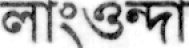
লাংওন্দা
